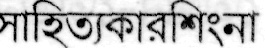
সাহিত্যকারশিংনা
